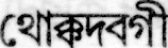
থোক্কদবগী
